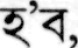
হ'ব,
